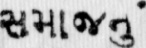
સમાજનું
